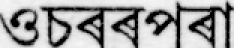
ওচৰৰপৰা
